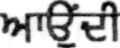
ਆਉਂਦੀ
